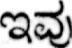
ಇವು
